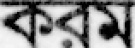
করম
